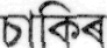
চাকিৰ
